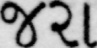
જરા
